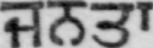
ਜਨਤਾ
